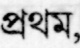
প্রথম,
